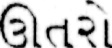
ઊતરો
